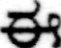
ಈ
